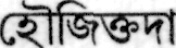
হৌজিক্তদা
